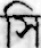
সি
